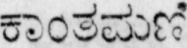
ಕಾಂತಮಣಿ
